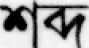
শব্দ
